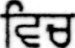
ਵਿਚ
